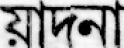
য়াদনা
